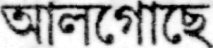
আলগোছে
